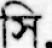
সি.
